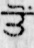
ਤੋਂ
